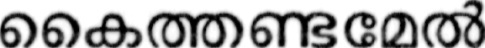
കൈത്തണ്ടമേല്‍
